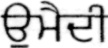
ਉਮੈਦੀ
